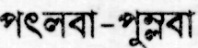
পৎলবা-পুম্লবা
